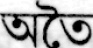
অতৈ
